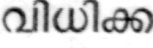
വിധിക്ക
